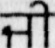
ਜੀ
